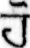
ਹੋ
